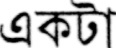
একটা
